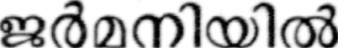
ജര്‍മനിയില്‍
